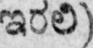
ಇರಲಿ)
